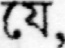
যে,
